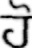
ਹੋ
